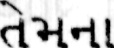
તેમના
